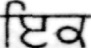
ਇਕ
